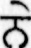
ਨੇ
